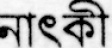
নাৎকী
